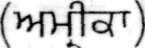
(ਅਮ੍ਰੀਕਾ)
